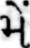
મેં
